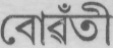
বোৱঁতী
